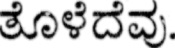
ತೊಳೆದೆವು.
